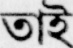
তাই
